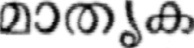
മാതൃക
